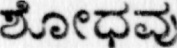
ಶೋಧವು
